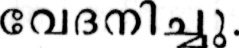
വേദനിച്ചു.
